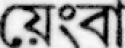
য়েংবা
